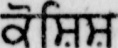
ਕੋਸ਼ਿਸ਼
